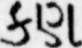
કણ
